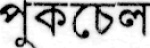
পুকচেল
